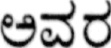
ಅವರ
